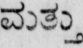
ಮತ್ತು
